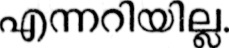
എന്നറിയില്ല.
